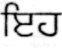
ਇਹ
